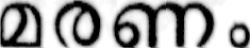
മരണം
